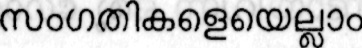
സംഗതികളെയെല്ലാം
